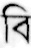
বি
